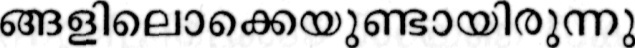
ങ്ങളിലൊക്കെയുണ്ടായിരുന്നു
